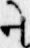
ને
